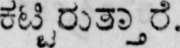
ಕಟ್ಟಿರುತ್ತಾರೆ.
